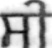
ਸੀ
